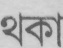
থকা
